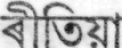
ৰীতিয়া
